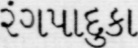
રંગપાદુકા
